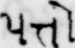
પત્તો
